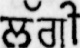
ਲੱਗੀ
